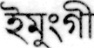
ইমুংগী
